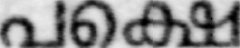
പക്ഷെ
